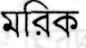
মরিক
